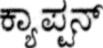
ಕ್ಯಾಪ್ಟನ್
